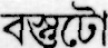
বস্তুটো
